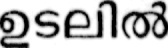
ഉടലില്‍
